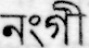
নংগী
